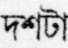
দশটা
